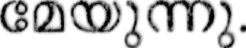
മേയുന്നു.
